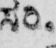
ಸರಿ.
